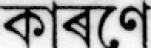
কাৰণে
